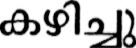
കഴിച്ചു
